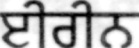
ਈਰੀਨ
